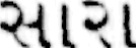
સારા
